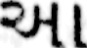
આ
